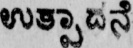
ಉತ್ಪಾದನೆ
